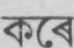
কৰে
